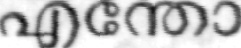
എന്തോ
